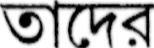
তাদের
